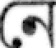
নে
